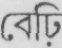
বেঢ়ি
